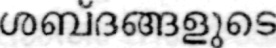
ശബ്ദങ്ങളുടെ
